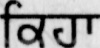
ਕਿਹਾ
